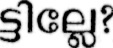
ട്ടില്ലേ?
